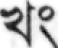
খং
